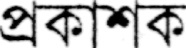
প্রকাশক
